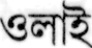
ওলাই
